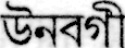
উনবগী
